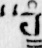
''ਹੂੰ
